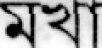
মখা
